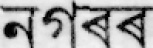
নগৰৰ
